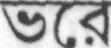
ভরে
